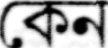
কেন
